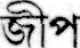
জীপ
